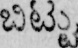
ಬಿಟ್ಟು
